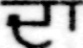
ਦਾ
